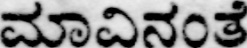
ಮಾವಿನಂತೆ
